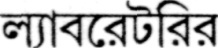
ল্যাবরেটরির
